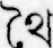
থৈ
